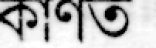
কাণত
